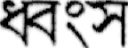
ধবংস
